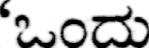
'ಒಂದು
